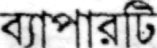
ব্যাপারটি
